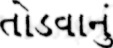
તોડવાનું
